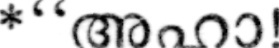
*"അഹാ!
